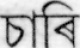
চাৰি
